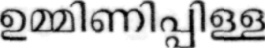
ഉമ്മിണിപ്പിള്ള
